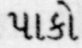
પાકો
